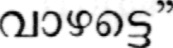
വാഴട്ടെ"
